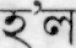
হ'ল
